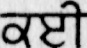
ਕਈ
